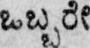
ಒಬ್ಬರೇ
